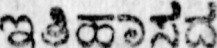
ಇತಿಹಾಸದ
